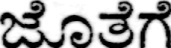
ಜೊತೆಗೆ
